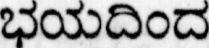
ಭಯದಿಂದ
